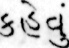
કહેવું
